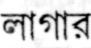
লাগার
